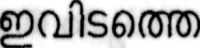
ഇവിടത്തെ
